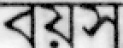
বয়স
